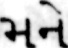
મને
